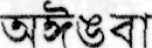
অঈঙবা
